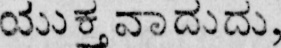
ಯುಕ್ತವಾದುದು,
